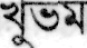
খুভম
